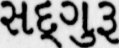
સદગુરૂ
